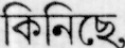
কিনিছে,
